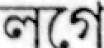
লগে
